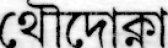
থৌদোক্না
